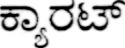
ಕ್ಯಾರಟ್
